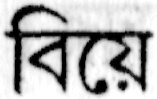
বিয়ে
